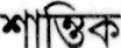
শান্তিক
